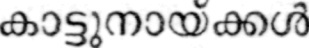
കാട്ടുനായ്ക്കള്‍
